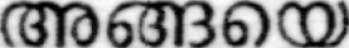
അങ്ങയെ
